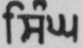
ਸਿੰਘ
